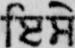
ਇਸੇ
